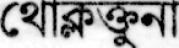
থোক্লক্তুনা
